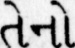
તેનો
